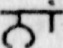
ਨਾਂ
